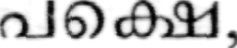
പക്ഷെ,
